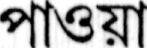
পাওয়া
